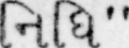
નિધિ"
